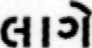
લાગે
